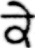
ਕੇ
